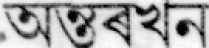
অন্তৰখন
